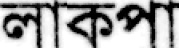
লাকপা
